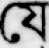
যে
